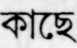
কাছে
